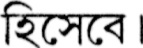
হিসেবে।
